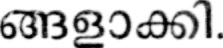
ങ്ങളാക്കി.
